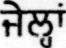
ਜੇਲ੍ਹਾਂ
